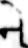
ને
